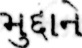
મુદ્દાને
